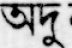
অদু
